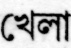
খেলা
